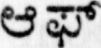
ಆಫ್
